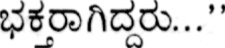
ಭಕ್ತರಾಗಿದ್ದರು..."
